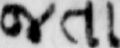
જતા
